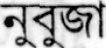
নুবুজা
